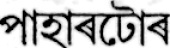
পাহাৰটোৰ
